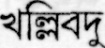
খল্লিবদু
